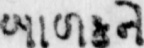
બાળકને
